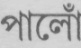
পালোঁ
